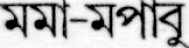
মমা-মপাবু
